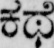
ಕಥೆ
